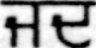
ਜਦ
